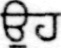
ਉਹ
